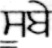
ਸੂਬੇ
